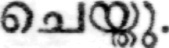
ചെയ്തു.
